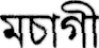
মচাগী
